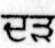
ਦੜ
